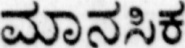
ಮಾನಸಿಕ
